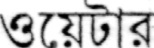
ওয়েটার
